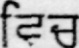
ਵਿਚ
